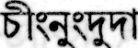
চীংনুংদুদা
